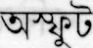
অস্ফুট
